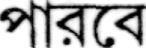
পারবে
